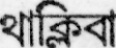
থাক্লিবা
